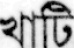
খাটি
